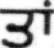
ਤਾਂ
